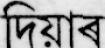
দিয়াৰ
